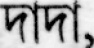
দাদা,
